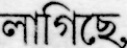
লাগিছে,
